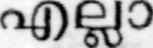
എല്ലാ
